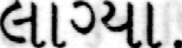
લાગ્યા.
